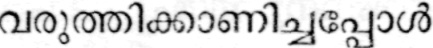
വരുത്തിക്കാണിച്ചപ്പോള്‍
